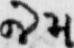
જેમ
